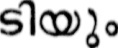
ടിയും
